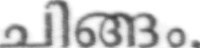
ചിങ്ങം,
